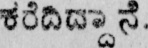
ಕರೆದಿದ್ದಾನೆ.
